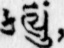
કહ્યું,
